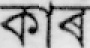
কাৰ
